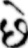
છે
